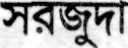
সরজুদা
